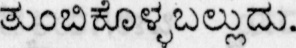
ತುಂಬಿಕೊಳ್ಳಬಲ್ಲುದು.
